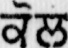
ਕੋਲ
